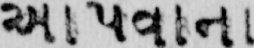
આપવાના
